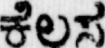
ಕೆಲಸ
